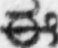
ಈ
